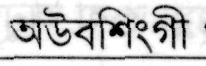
অউবশিংগী
